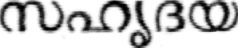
സഹൃദയ
